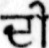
ਦੀ
